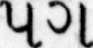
પગ
